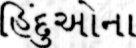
હિંદુઓના
